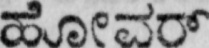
ಹೋವರ್
